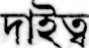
দাইত্ব
